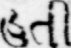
હતી
